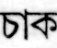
চাক
